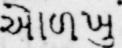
ઓળખું
